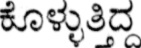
ಕೊಳ್ಳುತ್ತಿದ್ದ
